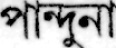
পান্দুনা
